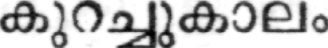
കുറച്ചുകാലം
